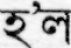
হ'ল
